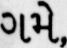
ગમે,
